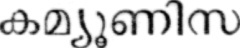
കമ്യൂണിസ
